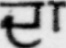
ਦਾ
